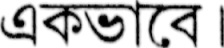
একভাবে।
